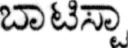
ಬಾಟಿಸ್ಟಾ
